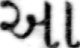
આ
